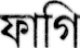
ফাগি
